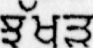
ਝੱਖੜ
